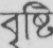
বৃষ্টি
